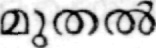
മുതല്‍
